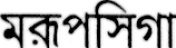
মরূপসিগা
